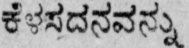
ಕೆಳಸದನವನ್ನು
